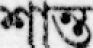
শান্ত
